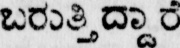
ಬರುತ್ತಿದ್ದಾರೆ
